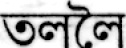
তললৈ
